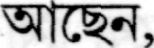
আছেন,
